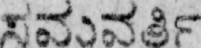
ಸಮವರ್ತಿ
